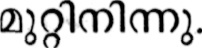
മുറ്റിനിന്നു.
